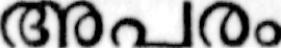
അപരം
